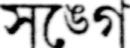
সঙ্গে
